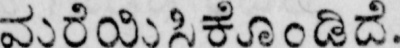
ಮರೆಯಿಸಿಕೊಂಡಿದೆ.
